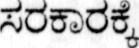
ಸರಕಾರಕ್ಕೆ
